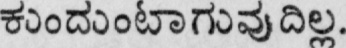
ಕುಂದುಂಟಾಗುವುದಿಲ್ಲ.
